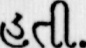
હતી.
